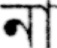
না
